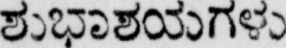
ಶುಭಾಶಯಗಳು
